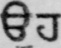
ਉਹ
